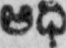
ಅಧಿ
